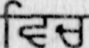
ਵਿਚ
